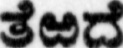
ತೆಱದೆ
